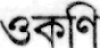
ওকণি
